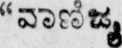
“ವಾಣಿಜ್ಯ
